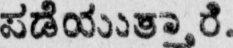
ಪಡೆಯುತ್ತಾರೆ.
